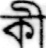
কী
